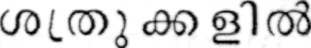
ശത്രുക്കളില്‍
